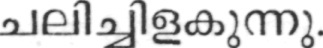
ചലിച്ചിളകുന്നു.
